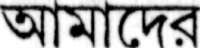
আমাদের
